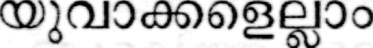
യുവാക്കളെല്ലാം
